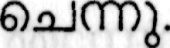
ചെന്നു.
